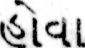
હોવા
